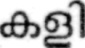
കളി
